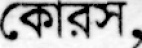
কোরস,
